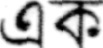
এক
